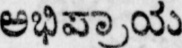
ಅಭಿಪ್ರಾಯ
